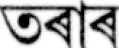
তৰাৰ
